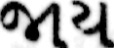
જાય
